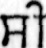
ਸੀ
